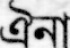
ঐনা
